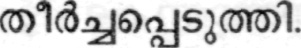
തീര്‍ച്ചപ്പെടുത്തി.
